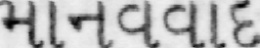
માનવવાદ
